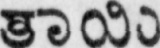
ತಾಯಿ
